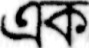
এক
